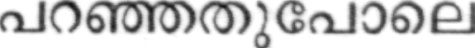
പറഞ്ഞതുപോലെ
